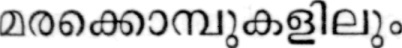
മരക്കൊമ്പുകളിലും
